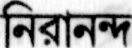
নিরানন্দ
